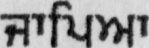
ਜਾਪਿਆ
